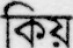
কিয়
